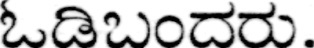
ಓಡಿಬಂದರು.
